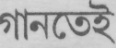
গানতেই
